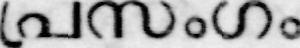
പ്രസംഗം
